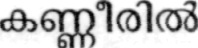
കണ്ണീരില്‍
